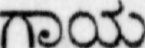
ಗಾಯ
